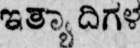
ಇತ್ಯಾದಿಗಳ
